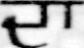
ਦਾ
